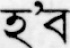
হ'ব
